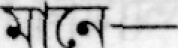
মানে-
